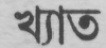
খ্যাত
